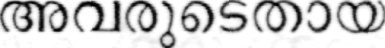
അവരുടെതായ
